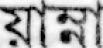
য়াম্না
